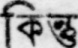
কিন্তু
